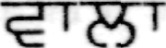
ਵਾਲਾ
